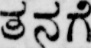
ತನಗೆ
